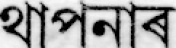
থাপনাৰ
